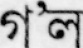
গ'ল
